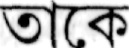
তাকে
